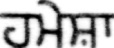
ਹਮੇਸ਼ਾ
